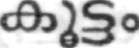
കൂട്ടം
